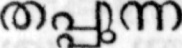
തപ്പുന്ന
